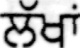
ਲੱਖਾਂ
